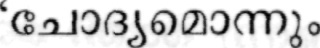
'ചോദ്യമൊന്നും
